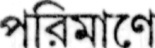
পরিমাণে
